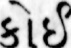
કોઈ
